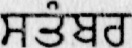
ਸਤੰਬਰ
